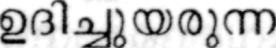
ഉദിച്ചുയരുന്ന
